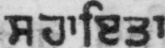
ਸਹਾਇਤਾ
